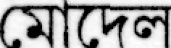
মোদেল
